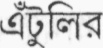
এঁটুলির
